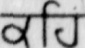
ਕਹਿ
